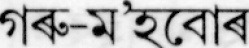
গৰু-ম'হবোৰ
